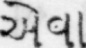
એવા
